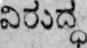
ವಿರುದ್ಧ
